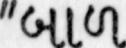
"બાળ
